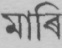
মাৰি
